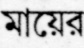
মায়ের
